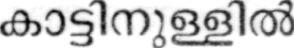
കാട്ടിനുള്ളില്‍
